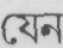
যেন
